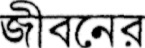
জীবনের
